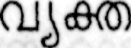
വ്യക്ത
